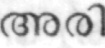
അരി
